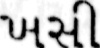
ખસી
